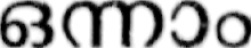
ഒന്നാം
